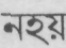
নহয়
